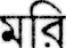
মরি
